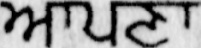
ਆਪਣਾ
